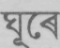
ঘূৰে
